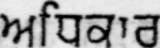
ਅਧਿਕਾਰ
